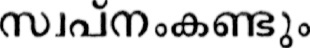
സ്വപ്നംകണ്ടും
